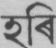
হৰি
